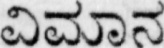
ವಿಮಾನ
